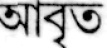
আবৃত
